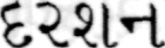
દરશન
